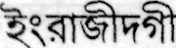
ইংরাজীদগী
